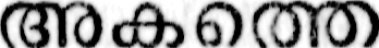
അകത്തെ
